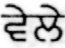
ਵੇਲੇ
